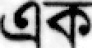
এক
